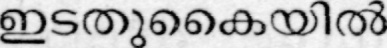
ഇടതുകൈയില്‍
